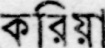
করিয়া
